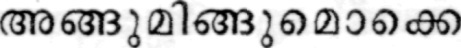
അങ്ങുമിങ്ങുമൊക്കെ
